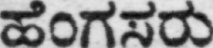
ಹೆಂಗಸರು
